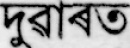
দুৱাৰত
